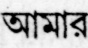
আমার
